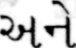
અને
